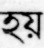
হয়
